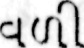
વળી
